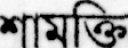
শামক্তি
